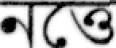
নত্তে
